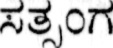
ಸತ್ಸಂಗ
